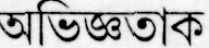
অভিজ্ঞতাক
